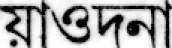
য়াওদনা
